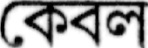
কেবল
